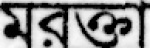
মরক্তা
